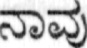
ನಾವು
